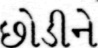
છોડીને
